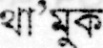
থা’মুর
